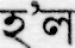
হ'ল
